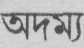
অদম্য
